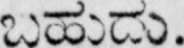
ಬಹುದು.
